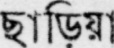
ছাড়িয়া
